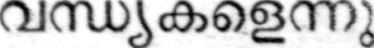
വന്ധ്യകളെന്നു
